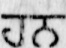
ਹਨ
